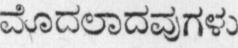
ಮೊದಲಾದವುಗಳು
